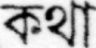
কথা
